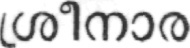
ശ്രീനാര
